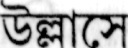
উল্লাসে
